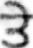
ਤੇ
